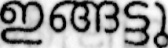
ഇങ്ങട്ടു
